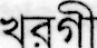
খরগী
